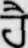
ਹੈ
